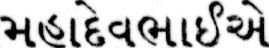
મહાદેવભાઈએ
